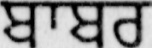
ਬਾਬਰ
